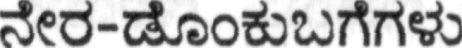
ನೇರ-ಡೊಂಕುಬಗೆಗಳು
